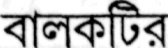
বালকটির
